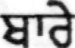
ਬਾਰੇ
